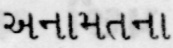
અનામતના
